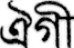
ঐগী
